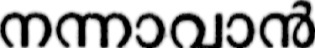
നന്നാവാന്‍
